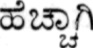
ಹೆಚ್ಚಾಗಿ
